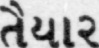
તૈયાર
